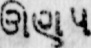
ઉણપ
